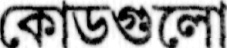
কোডগুলো
